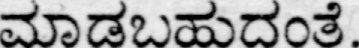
ಮಾಡಬಹುದಂತೆ.
